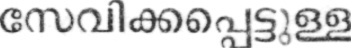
സേവിക്കപ്പെട്ടുള്ള
